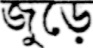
জুড়ে
